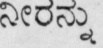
ನೀರನ್ನು
